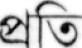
প্রতি
